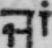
ਜਾਂ
